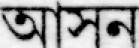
আসন
